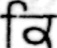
ਕਿ
